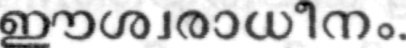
ഈശ്വരാധീനം.
